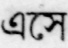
এসে
